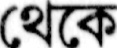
থেকে
